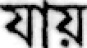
যায়
